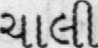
ચાલી
